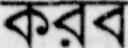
করব
